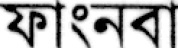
ফাংনবা
